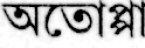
অতোপ্পা
